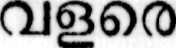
വളരെ
